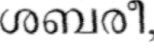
ശബരീ,
